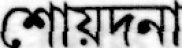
শোয়দনা
